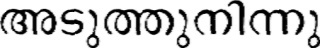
അടുത്തുനിന്നു
